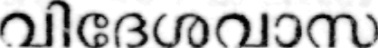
വിദേശവാസ
